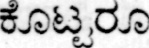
ಕೊಟ್ಟರೂ
